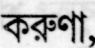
করুণা,
